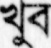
খুব
